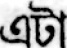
এটা
